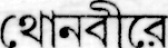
থোনবীরে
